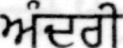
ਅੰਦਰੀ
